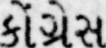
કોંગ્રેસ
